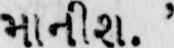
માનીશ.'
